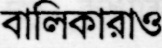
বালিকারাও
